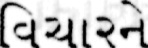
વિચારને
